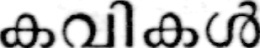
കവികള്‍
